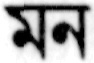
মন
